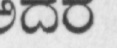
ಅದರ
